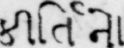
કીર્તિનો
